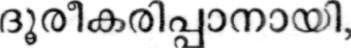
ദൂരീകരിപ്പാനായി,
